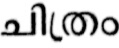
ചിത്രം
